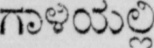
ಗಾಳಿಯಲ್ಲಿ
